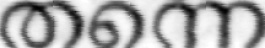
തന്നെ
